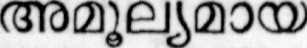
അമൂല്യമായ
